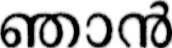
ഞാന്‍
